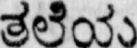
ತಲೆಯ
